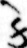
કે
